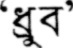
‘ধ্রুব’
